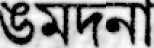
ঙমদনা
